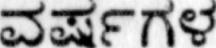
ವರ್ಷಗಳ
